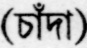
(চাঁদা)
